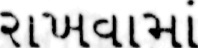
રાખવામાં
